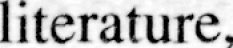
literature,
